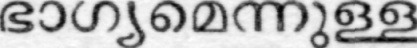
ഭാഗ്യമെന്നുള്ള
